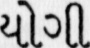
યોગી
